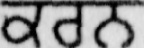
ਕਰਨ
